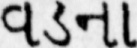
વડના
